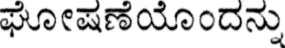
ಘೋಷಣೆಯೊಂದನ್ನು
